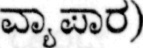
ವ್ಯಾಪಾರ)
